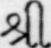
શ્રી
